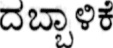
ದಬ್ಬಾಳಿಕೆ
